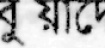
বু য়াদে
